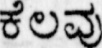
ಕೆಲವು
